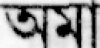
অমা
